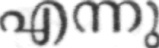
എന്നു
